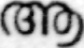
ആ
